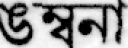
ঙম্বনা
